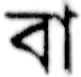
বা
